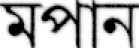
মপান
